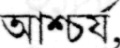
আশ্চর্য,
